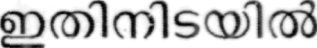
ഇതിനിടയില്‍
